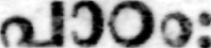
പാഠം:
